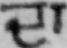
ਦਾ
